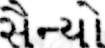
સૈન્યો
